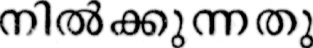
നില്‍ക്കുന്നതു
